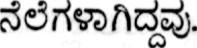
ನೆಲೆಗಳಾಗಿದ್ದವು.
